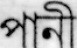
পানী
